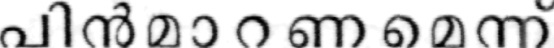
പിന്‍മാറണമെന്ന്
